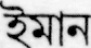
ইমান
